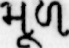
મૂળ
